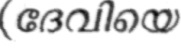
(ദേവിയെ
